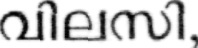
വിലസി,
